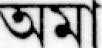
অমা
